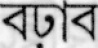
বঢ়াব
